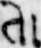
તો
